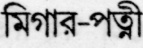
মিগার-পত্নী
